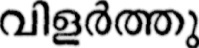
വിളര്‍ത്തു
